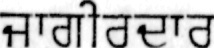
ਜਾਗੀਰਦਾਰ
